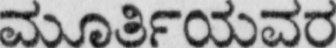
ಮೂರ್ತಿಯವರ
